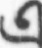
এ
